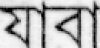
যাবা
